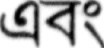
এবং
